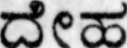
ದೇಹ
